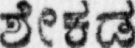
ಶೇಕಡ
